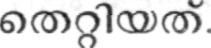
തെറ്റിയത്.
